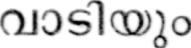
വാടിയും
